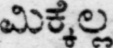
ಮಿಕ್ಕೆಲ್ಲ
